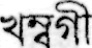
খম্বগী
